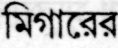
মিগারের
